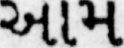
આમ
